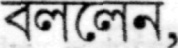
বললেন,
